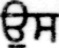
ਉਸ
